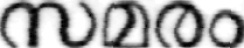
സമരം
